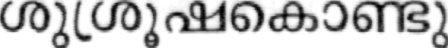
ശുശ്രൂഷകൊണ്ടു
